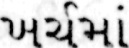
ખર્ચમાં
